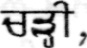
ਚੜ੍ਹੀ,
